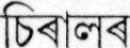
চিৰালৰ
